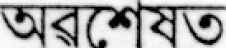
অৱশেষত
